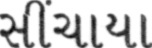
સીંચાયા
